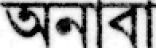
অনাবা
